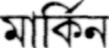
মার্কিন
